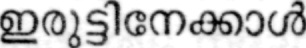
ഇരുട്ടിനേക്കാള്‍
